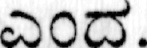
ಎಂದ.
